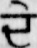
ਦੇ
